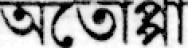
অতোপ্পা
